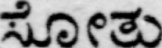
ಸೋತು
